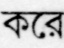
করে
